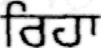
ਰਿਹਾ
